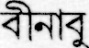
বীনাবু
